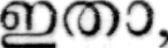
ഇതാ,
